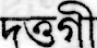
দত্তগী
